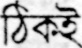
ঠিকই
